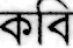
কবি
